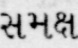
સમક્ષ
